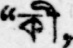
‘‘কী,
